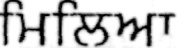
ਮਿਲਿਆ
